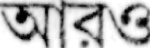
আরও
